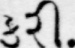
કરી.
